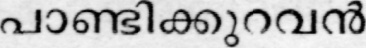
പാണ്ടിക്കുറവന്‍
